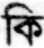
কি
